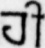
ਹੀ
